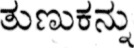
ತುಣುಕನ್ನು
